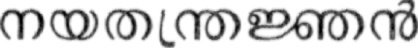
നയതന്ത്രജ്ഞന്‍
